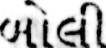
બોલી
